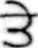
ਤੇ
